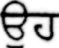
ਉਹ
